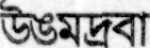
উঙমদ্রবা
